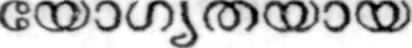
യോഗ്യതയായ
